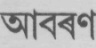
আবৰণ
